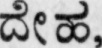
ದೇಹ,
